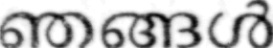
ഞങ്ങള്‍
